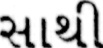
સાથી
